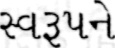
સ્વરૂપને
